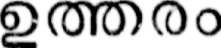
ഉത്തരം
